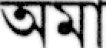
অমা
